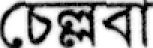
চেল্লবা
